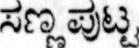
ಸಣ್ಣಪುಟ್ಟ
